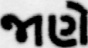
જાણે
